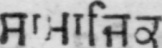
ਸਾਮਾਜਿਕ
